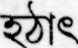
হঠাৎ
